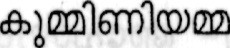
കുമ്മിണിയമ്മ
